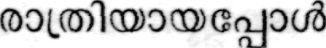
രാത്രിയായപ്പോള്‍
